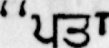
''ਪਤਾ
